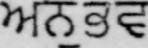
ਅਨੁਭਵ
